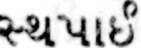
સ્થપાઈ
